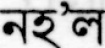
নহ'ল
